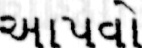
આપવો
